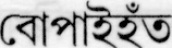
বোপাইহঁত
